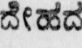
ದೇಹದ
